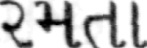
રમતા
